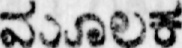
ಮೂಲಕ
